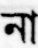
না
